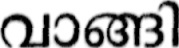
വാങ്ങി
